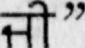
ਜੀ''
